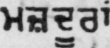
ਮਜ਼ਦੂਰਾਂ
